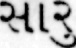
સારુ
